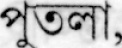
পুতলা,
